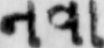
નવા
